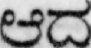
ಆದ
